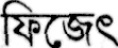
ফিজেৎ
